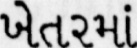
ખેતરમાં
